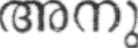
അനു
